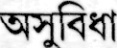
অসুবিধা
